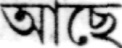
আছে
